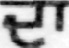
ਦਾ
